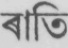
ৰাতি
